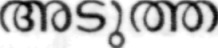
അടുത്ത
